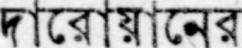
দারোয়ানের
